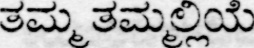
ತಮ್ಮತಮ್ಮಲ್ಲಿಯೆ
